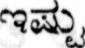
ಇಷ್ಟು
